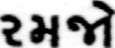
રમજો
